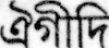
ঐগীদি
